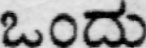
ಒಂದು
